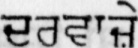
ਦਰਵਾਜ਼ੇ
